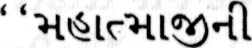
"મહાત્માજીની
